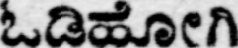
ಓಡಿಹೋಗಿ
